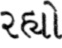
રહ્યો
